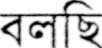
বলছি
